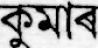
কুমাৰ
